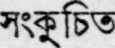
সংকুচিত
